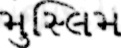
મુસ્લિમ
